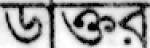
ডাক্তর
